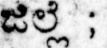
ಜಿಲ್ಲೆ;
